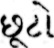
છૂટો
